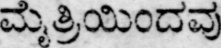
ಮೈತ್ರಿಯಿಂದವು
